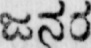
ಜನರ
